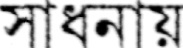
সাধনায়
